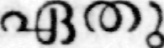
ഏതു
